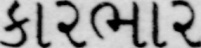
કારભાર
